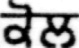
ਕੋਲ
